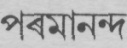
পৰমানন্দ
